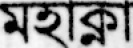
মহাক্না
